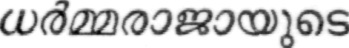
ധര്‍മ്മരാജായുടെ
